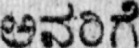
ಅವರಿಗೆ
